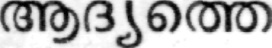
ആദ്യത്തെ
